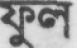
ফুল
